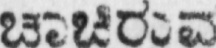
ಚಾಚಿರುವ
